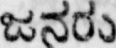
ಜನರು
